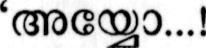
‘അയ്യോ...!
